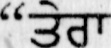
''ਤੇਰਾ
